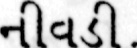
નીવડી.
